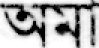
অমা
